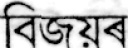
বিজয়ৰ
